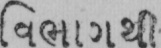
વિભાગથી
